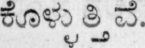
ಕೊಳ್ಳುತ್ತಿವೆ.
